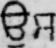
ਉਸ
